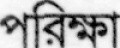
পরিক্ষা
